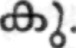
കു.
